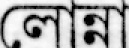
লোন্না
